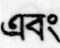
এবং
